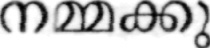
നമ്മക്കു
